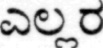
ಎಲ್ಲರ
